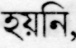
হয়নি,
